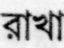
রাখা
